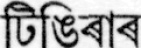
টিঙিৰাৰ
